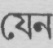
যেন
